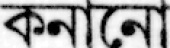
কনানো
